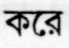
করে
